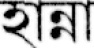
হান্না
